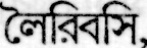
লৈরিবসি,
